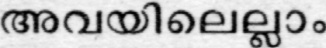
അവയിലെല്ലാം
